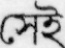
সেই
